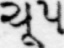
ચૂપ
